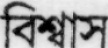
বিশ্বাস
